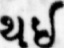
થઈ
